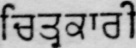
ਚਿਤ੍ਰਕਾਰੀ
